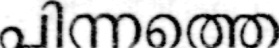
പിന്നത്തെ
